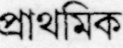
প্রাথমিক
